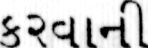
કરવાની
